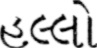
હલ્લો
